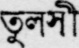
তুলসী
